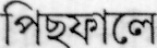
পিছফালে
